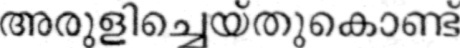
അരുളിച്ചെയ്തുകൊണ്ട്
